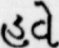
હવે
